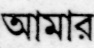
আমার
